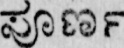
ಪೂರ್ಣ
